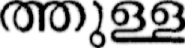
ത്തുള്ള
